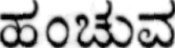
ಹಂಚುವ
